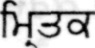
ਮ੍ਰਿਤਕ
